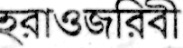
হরাওজরিবী
